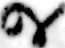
જ
